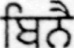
ਬਿਨੈ
